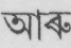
আৰু
